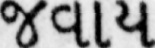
જવાય
